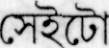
সেইটো
